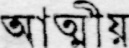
আত্মীয়
